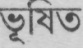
ভূষিত
